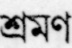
শ্রমণ
